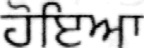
ਹੋਇਆ
